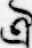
ঐ
